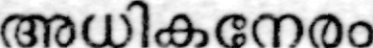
അധികനേരം
